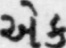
એક
